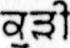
ਕੁੜੀ
